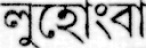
লুহোংবা
